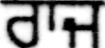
ਰਾਜ
